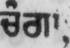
ਚੰਗਾ,
